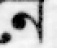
নে
